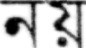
নয়
